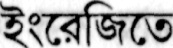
ইংরেজিতে
